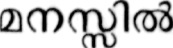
മനസ്സില്‍
